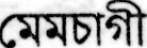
মেমচাগী
